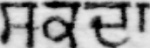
ਸਕਦਾ
